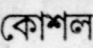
কোশল
